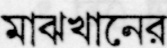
মাঝখানের
